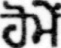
ਹੋਮੇਂ
